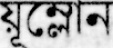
য়ূম্লোন
